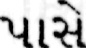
પાસે
